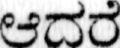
ಆದರೆ
